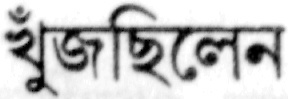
খুঁজছিলেন
